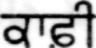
ਕਾਫ਼ੀ
